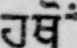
ਹਥੋਂ
